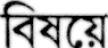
বিষয়ে
